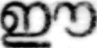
ഈ
